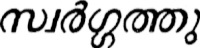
സ്വര്‍ഗ്ഗത്തു
